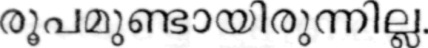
രൂപമുണ്ടായിരുന്നില്ല.
